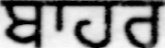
ਬਾਹਰ
